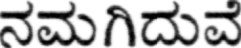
ನಮಗಿದುವೆ
